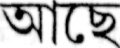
আছে
